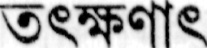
তৎক্ষণাৎ
